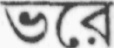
ভরে
